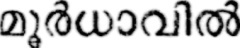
മൂര്‍ധാവില്‍
